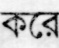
করে
